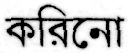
করিনো
